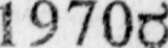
1970ರ
